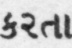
કરતા
